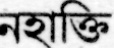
নহাক্তি
